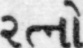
રત્નો
